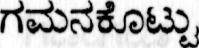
ಗಮನಕೊಟ್ಟು
